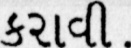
કરાવી.
